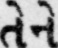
તેને
